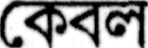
কেবল
